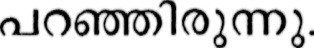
പറഞ്ഞിരുന്നു.
